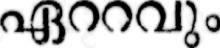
ഏററവും
